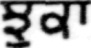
ਝੁਕਾ
